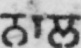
ਨਾਲ
